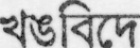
খঙবিদে
